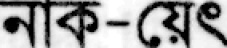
নাক-য়েৎ
